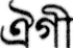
ঐগী
